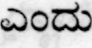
ಎಂದು
